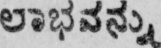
ಲಾಭವನ್ನು
